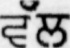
ਵੱਲ
